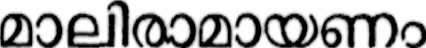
മാലിരാമായണം
